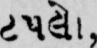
ટપલો,
